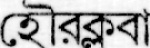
হৌরক্লবা
